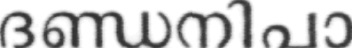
ദണ്ഡനിപാ
